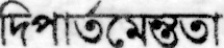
দিপার্তমেন্ততা
